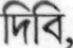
দিবি,
